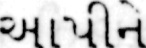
આપીને
